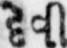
દેવી
